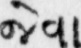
જેવા
